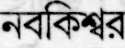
নবকিশ্বর
